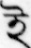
ই
